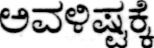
ಅವಳಿಷ್ಟಕ್ಕೆ
